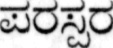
ಪರಸ್ಪರ
